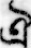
ঐ
